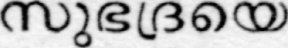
സുഭദ്രയെ
